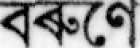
বৰুণে
